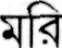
মরি
